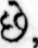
છે,
